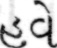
હવે
